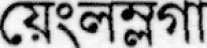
য়েংলম্লগা
